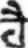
ਹੈ
